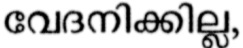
വേദനിക്കില്ല,
